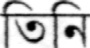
তিনি
